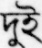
দুই
